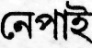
নেপাই
